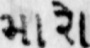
મારો
